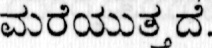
ಮರೆಯುತ್ತದೆ.
